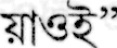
য়াওই”
